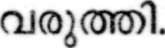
വരുത്തി.
